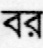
বর
